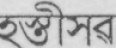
হস্তীসৱ
